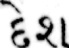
દેશ
